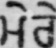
ਮੇਰੇ
